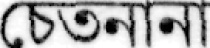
চেতনানা
